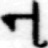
ન
